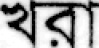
খরা
